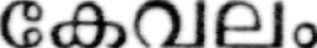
കേവലം
